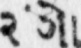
રંગો
